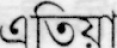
এতিয়া
